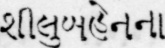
શીલુબહેનના
